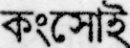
কংসোই
